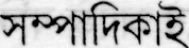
সম্পাদিকাই
